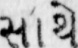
સાથે
